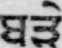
ਬੜੇ
